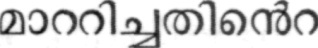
മാററിച്ചതിന്റെ
